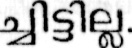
ച്ചിട്ടില്ല.
